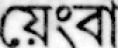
য়েংবা
